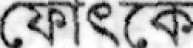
ফোৎকে
